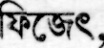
ফিজেৎ,
